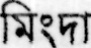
মিংদা
